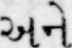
અને
